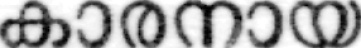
കാരനായ
